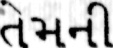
તેમની
